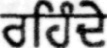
ਰਹਿੰਦੇ
